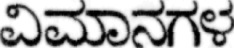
ವಿಮಾನಗಳ
